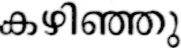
കഴിഞ്ഞു
